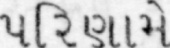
પરિણામે
